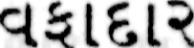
વફાદાર
